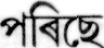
পৰিছে
